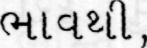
ભાવથી,
